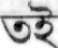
তই
